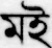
মই
